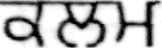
ਕਲਮ
